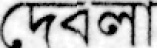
দেবলা
